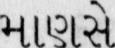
માણસે
